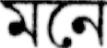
মনে
